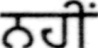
ਨਹੀਂ
